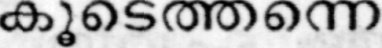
കൂടെത്തന്നെ
